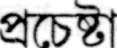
প্রচেষ্টা
